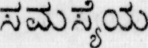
ಸಮಸ್ಯೆಯ
